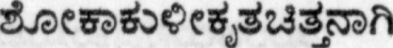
ಶೋಕಾಕುಳೀಕೃತಚಿತ್ತನಾಗಿ
